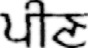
ਪੀਣ
